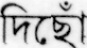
দিছোঁ
